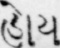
હોય
